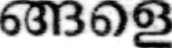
ങ്ങളെ
